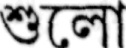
শুলো
